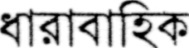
ধারাবাহিক
